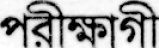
পরীক্ষাগী
